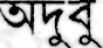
অদুবু
